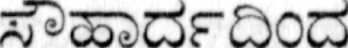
ಸೌಹಾರ್ದದಿಂದ
